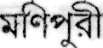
মণিপুরী
